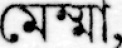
মেম্মা,
